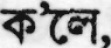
ক'লে,
